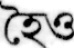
হৈও
